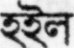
হইল
